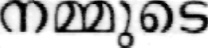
നമ്മുടെ
